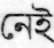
নেই
